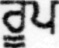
ਰੂਪ
